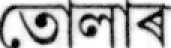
তোলাৰ
